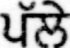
ਪੱਲੇ
